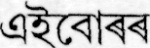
এইবোৰৰ
